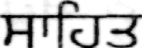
ਸਾਹਿਤ
